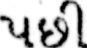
પછી
